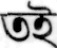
তই
